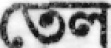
তেল
